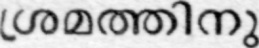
ശ്രമത്തിനു
